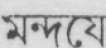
মন্দযে
